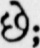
છે;
